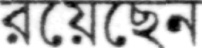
রয়েছেন
